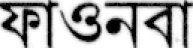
ফাওনবা
